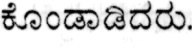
ಕೊಂಡಾಡಿದರು.
